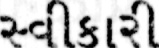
સ્વીકારી
